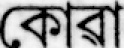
কোৱা
